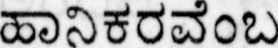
ಹಾನಿಕರವೆಂಬ
